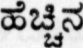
ಹೆಚ್ಚಿನ
